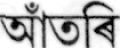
আঁতৰি
